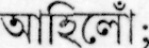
আহিলোঁ;
